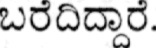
ಬರೆದಿದ್ದಾರೆ.
